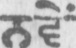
ਨਵੇਂ
